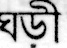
ঘড়ী
